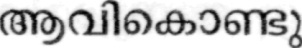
ആവികൊണ്ടു
